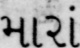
મારાં
